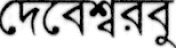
দেবেশ্বরবু
